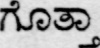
ಗೊತ್ತಾ
